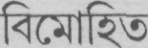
বিমোহিত
